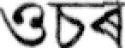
ওচৰ
